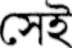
সেই
